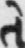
તે
